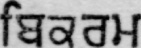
ਬਿਕਰਮ
